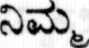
ನಿಮ್ಮ
